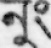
নুং
